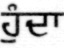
ਹੁੰਦਾ
